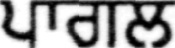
ਪਾਗਲ
